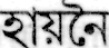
হায়নৈ
